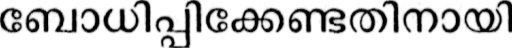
ബോധിപ്പിക്കേണ്ടതിനായി
